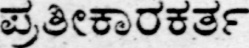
ಪ್ರತೀಕಾರಕರ್ತ
